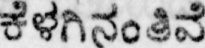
ಕೆಳಗಿನಂತಿವೆ
